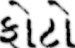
ફોટો
